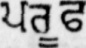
ਪਰੂਫ
